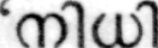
'നിധി
